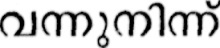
വന്നുനിന്ന്
